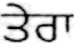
ਤੇਰਾ
